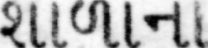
શાળાના
